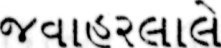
જવાહરલાલે
